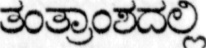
ತಂತ್ರಾಂಶದಲ್ಲಿ
